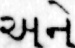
અને
